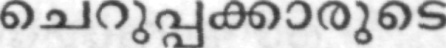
ചെറുപ്പക്കാരുടെ
